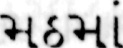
મઠમાં
